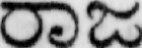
ರಾಜ
